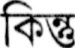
কিন্তু
